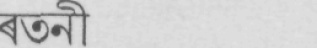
ৰতনী
